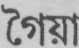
গৈয়া
